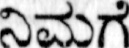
ನಿಮಗೆ
